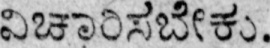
ವಿಚಾರಿಸಬೇಕು.
